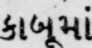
કાબૂમાં
